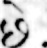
છે.
